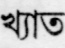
খ্যাত
